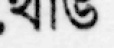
থোঙ
